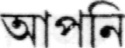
আপনি
